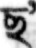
ছ'
